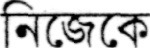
নিজেকে
